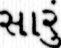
સારું
